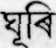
ঘূৰি
